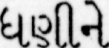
ધણીને
